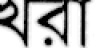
খরা
